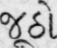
જૂઠો
